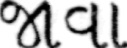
જાવા
